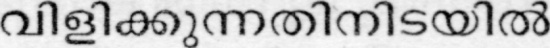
വിളിക്കുന്നതിനിടയില്‍
